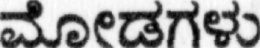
ಮೋಡಗಳು
